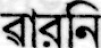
ৱারনি
